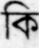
কি
